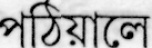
পঠিয়ালে
